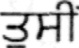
ਤੁਸੀਂ
